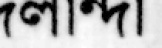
দলান্দা
